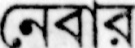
নেবার
